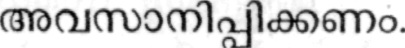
അവസാനിപ്പിക്കണം.
